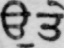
ਉਤੇ
